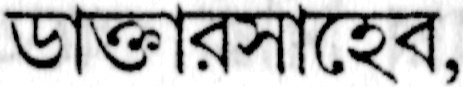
ডাক্তারসাহের,
